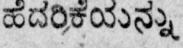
ಹೆದರಿಕೆಯನ್ನು
